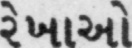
રેખાઓ
